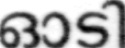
ഓടി
